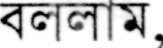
বললাম,
